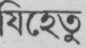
যিহেতু
